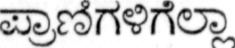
ಪ್ರಾಣಿಗಳಿಗೆಲ್ಲಾ
